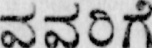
ವವರಿಗೆ
